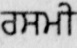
ਰਸਮੀ
